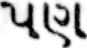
પણ
